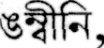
ঙম্বীনি,
